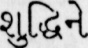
શુદ્ધિને
